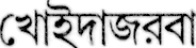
খোইদাজরবা
